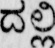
ದಲ್ಲಿ
